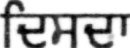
ਦਿਸਦਾ
